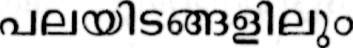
പലയിടങ്ങളിലും
